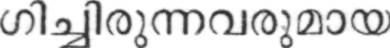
ഗിച്ചിരുന്നവരുമായ
